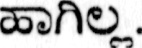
ಹಾಗಿಲ್ಲ.
